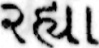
રહ્યા
